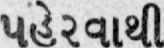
પહેરવાથી
